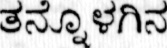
ತನ್ನೊಳಗಿನ
